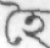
হৈ
